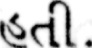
હતી.
